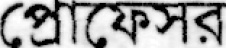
প্রোফেসর
